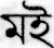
মই
